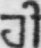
ਹੀ
